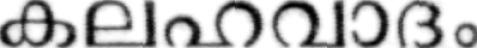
കലഹവാദം
